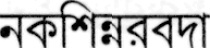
নকশিন্নরবদা
